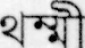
থম্মী
